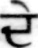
ਦੇ
